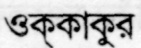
ওক্কাকুর
